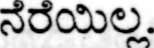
ನೆರೆಯಿಲ್ಲ.
